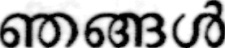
ഞങ്ങള്‍
